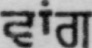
ਵਾਂਗ
